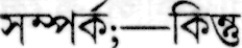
সম্পর্ক;-কিন্তু
